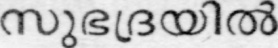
സുഭദ്രയില്‍
